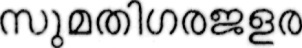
സുമതിഗരജളര
